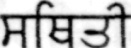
ਸਥਿਤੀ
